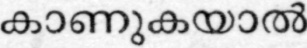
കാണുകയാല്‍
